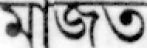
মাজত
